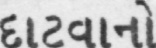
દાટવાનો
